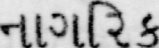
નાગરિક
